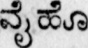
ವೈಹೊ
